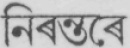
নিৰন্তৰে
